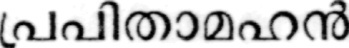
പ്രപിതാമഹന്‍
